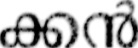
ക്കന്‍
